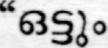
“ഒട്ടും
